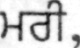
ਮਰੀ,
